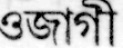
ওজাগী
